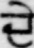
ਦੇ
